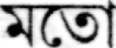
মতো
